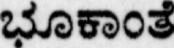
ಭೂಕಾಂತೆ
